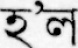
হ'ল
